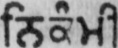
ਨਿਕੰਮੀ
